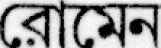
রোমেন
